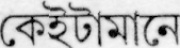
কেইটামানে
